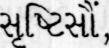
સૃષ્ટિસૌં,
